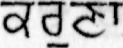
ਕਰੁਣਾ
